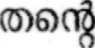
തന്റെ
